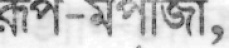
রূপ-মপ্াজা
